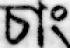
চাং
